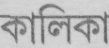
কালিকা
